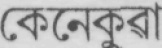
কেনেকুৱা
